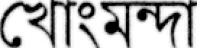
খোংমন্দা
